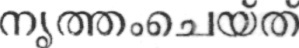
നൃത്തംചെയ്ത്
